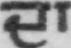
ਦਾ
